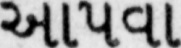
આપવા
